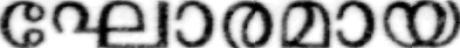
ഘോരമായ
